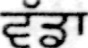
ਵੱਡਾ
